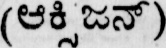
(ಆಕ್ಸಿಜನ್)
